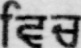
ਵਿਚ
